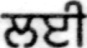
ਲਈ
